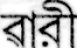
ৱারী
